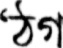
'ঠগ
